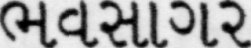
ભવસાગર
